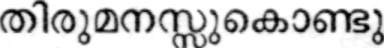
തിരുമനസ്സുകൊണ്ടു
